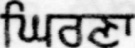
ਘਿਰਣਾ
